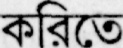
করিতে
